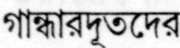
গান্ধারদূতদের
